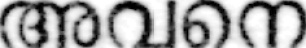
അവനെ
